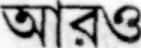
আরও
